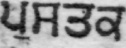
ਪੁਸਤਕ
